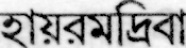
হায়রমদ্রিবা
